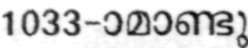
1033-ാമാണ്ടും
